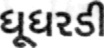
ધૂધરડી
